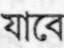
যাবে
